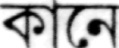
কানে
